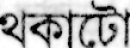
থকাটো
